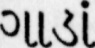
ગાડાં
